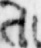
તો
